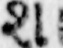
શા
